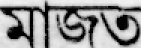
মাজত
